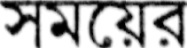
সময়ের
